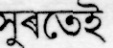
সুৰতেই
